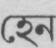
হেন
